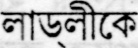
লাড্‌লীকে
